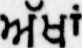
ਅੱਖਾਂ
